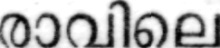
രാവിലെ
